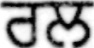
ਰਲ
